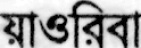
য়াওরিবা
